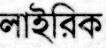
লাইরিক
